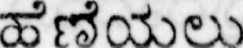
ಹೆಣೆಯಲು
